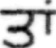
ਤਾਂ
